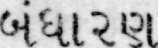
બંધારણ
